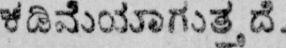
ಕಡಿಮೆಯಾಗುತ್ತದೆ.
